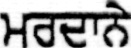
ਮਰਦਾਨੇ
